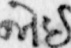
જોઈ
